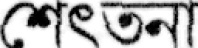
শেৎতনা
